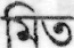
মিত
